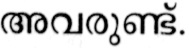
അവരുണ്ട്.
